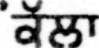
'ਕੱਲਾ
